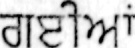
ਗਈਆਂ
